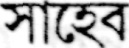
সাহেব
